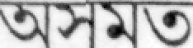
অসমত
